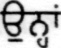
ਉਨ੍ਹਾਂ
